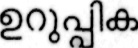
ഉറുപ്പിക
